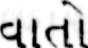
વાતો
